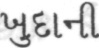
ખુદાની
